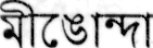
মীঙোন্দা
